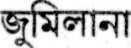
জুমিলানা
